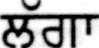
ਲੱਗਾ
